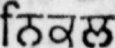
ਨਿਕਲ
